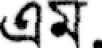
এম.
